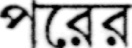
পরের
